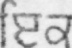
ਇਕ
